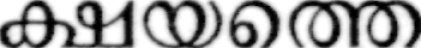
ക്ഷയത്തെ
